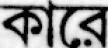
কারে
